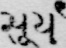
સૂર્ય
